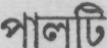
পালটি
